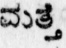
ಮತ್ತೆ
